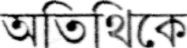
অতিথিকে
